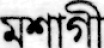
মশাগী
